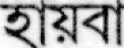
হায়বা
